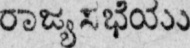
ರಾಜ್ಯಸಭೆಯು
